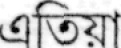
এতিয়া
